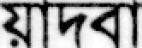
য়াদবা
